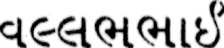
વલ્લભભાઈ
